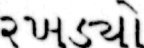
રખડ્યો
